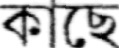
কাছে
